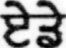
ਏਡੇ
